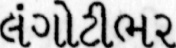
લંગોટીભર
